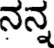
ನನ್ನ
